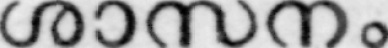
ശാസനം
